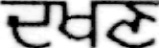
ਦਖਣ
